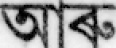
আৰু
